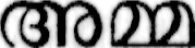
അമ്മ
